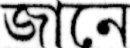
জানে
